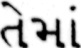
તેમાં
